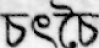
চৎচৈ
